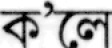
ক'লে
